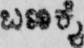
ಬಣಕ್ಕೆ
